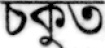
চকুত
